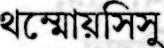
থম্মোয়সিসু
